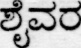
ಶೈವರ
